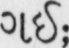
ગઈ;
